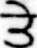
ਤੇ
